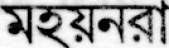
মহয়নরা
